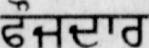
ਫੌਜਦਾਰ
